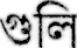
গুলি
